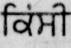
ਕਿਸੀ
